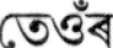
তেওঁৰ
